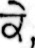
ਕੇ,
